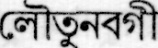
লৌতুনবগী
